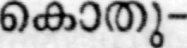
കൊതു-
